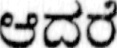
ಆದರೆ
